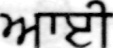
ਆਈ
